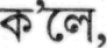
ক'লে,
